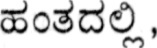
ಹಂತದಲ್ಲಿ,
